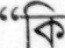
"কি
